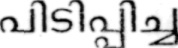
പിടിപ്പിച്ച
